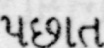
પછાત
